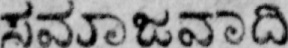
ಸಮಾಜವಾದಿ
